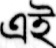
এই
